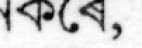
নকৰে,
